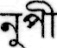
নুপী
